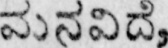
ಮನವಿದೆ,
